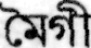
মৈগী
